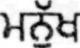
ਮਨੁੱਖ
